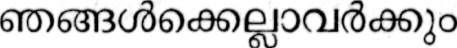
ഞങ്ങള്‍ക്കെല്ലാവര്‍ക്കും
